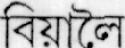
বিয়ালৈ
